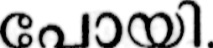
പോയി.
